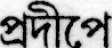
প্ৰদীপে
